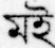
মই
